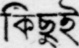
কিছুই
